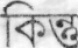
কিন্তু
